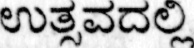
ಉತ್ಸವದಲ್ಲಿ
